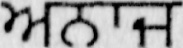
ਅਨਾਜ
